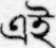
এই
